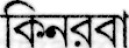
কিনরবা
